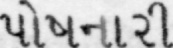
પોષનારી
